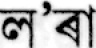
ল'ৰা
